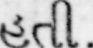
હતી.
